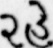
રહે
